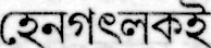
হেনগৎলকই
